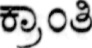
ಕ್ರಾಂತಿ
